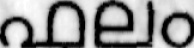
ഫലം
